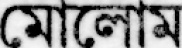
মোলোম
